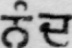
ਨੰਦ
